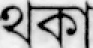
থকা
